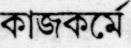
কাজকর্মে
